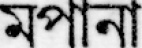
মপানা
